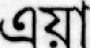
এয়া
